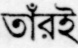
তাঁরই
